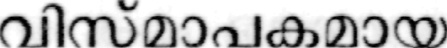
വിസ്മാപകമായ
